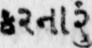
કરનારું
